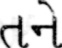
તને
